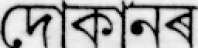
দোকানৰ
